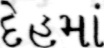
દેહમાં
